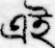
এই
